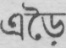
এড়ৈ
